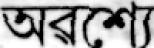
অৱশ্যে
